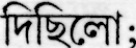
দিছিলো;
